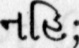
નહિ;
